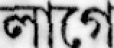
লাগে
